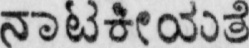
ನಾಟಕೀಯತೆ
